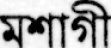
মশাগী
